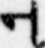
ન
